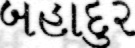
બહાદુર
